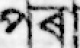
পৰা
